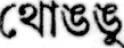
থোঙঙু
